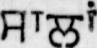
ਸਾਲਾਂ
